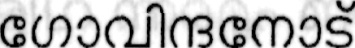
ഗോവിന്ദനോട്
